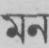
মন
